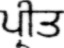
ਪ੍ਰੀਤ
